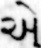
એ
